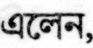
এলেন,
